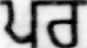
ਪਰ
